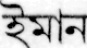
ইমান
